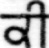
ਕੀ
